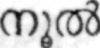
നൂല്‍
